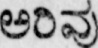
ಅರಿವು
